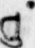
તું
